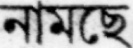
নামছে
